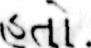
હતો.
